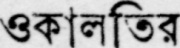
ওকালতির
